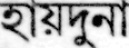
হায়দুনা
